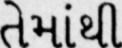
તેમાંથી
